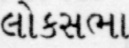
લોકસભા
